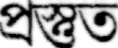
প্রস্তুত
